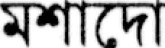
মশাদো
